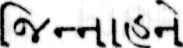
જિન્નાહને
